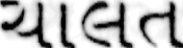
ચાલત
